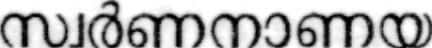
സ്വര്‍ണനാണയ
